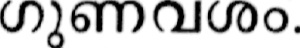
ഗുണവശം.
